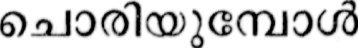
ചൊരിയുമ്പോള്‍
